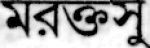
মরক্তসু
